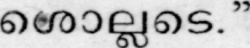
ശൊല്ലടെ."
